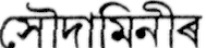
সৌদামিনীৰ
